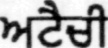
ਅਟੈਚੀ
